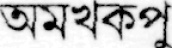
অমখকপু
